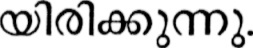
യിരിക്കുന്നു.
